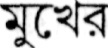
মুখের
